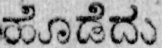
ಹೊಡೆದು
